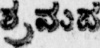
ಶ್ರಮದ
